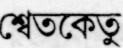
শ্বেতকেতু
